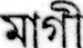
মাগী
